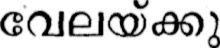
വേലയ്ക്കു
